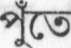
পুঁতে
